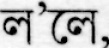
ল'লে,
